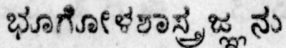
ಭೂಗೋಳಶಾಸ್ತ್ರಜ್ಞನು
